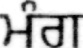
ਮੰਗ
